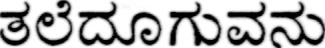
ತಲೆದೂಗುವನು
